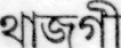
থাজগী
